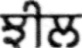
ਝੀਲ
